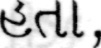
હતા,
